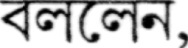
বললেন,
